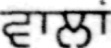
ਵਾਲਾਂ
